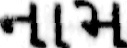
નામ
